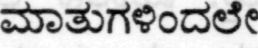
ಮಾತುಗಳಿಂದಲೇ
